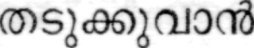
തടുക്കുവാന്‍
